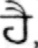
ਹੈ,
